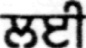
ਲਈ
